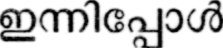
ഇന്നിപ്പോള്‍
